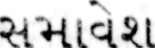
સમાવેશ
